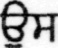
ਉਸ
